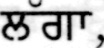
ਲੱਗਾ,
